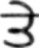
ਤੇ
